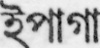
ইপাগা
